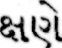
ક્ષણે
